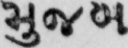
મુજબ
